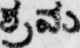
ಶ್ರಮ
